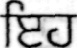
ਇਹ
